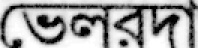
ভেলরদা
